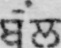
ਬੋਲ
